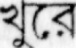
খুরে
